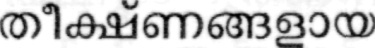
തീക്ഷ്ണങ്ങളായ
